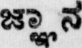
ಜ್ಞಾನ
